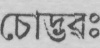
চোদ্ভৱঃ
